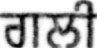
ਗਲੀ
